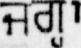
ਜਗ੍ਹਾ
